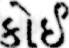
કોઈ
